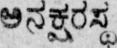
ಅನಕ್ಷರಸ್ಥ
